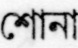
শোনা
